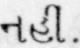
નહીં.
